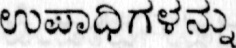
ಉಪಾಧಿಗಳನ್ನು
